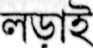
লড়াই
